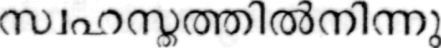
സ്വഹസ്തത്തില്‍നിന്നു
